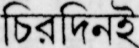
চিরদিনই
